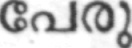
പേരു
